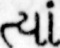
ત્યાં
